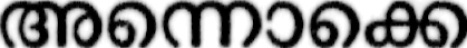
അന്നൊക്കെ
